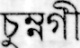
চুম্নগী
